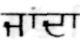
ਜਾਂਦਾ
